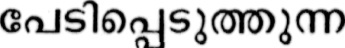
പേടിപ്പെടുത്തുന്ന
